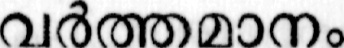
വര്‍ത്തമാനം
